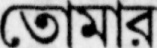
তোমার
